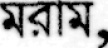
মরাম,
